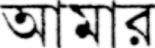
আমার
